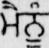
ਮੈਨੂੰ
